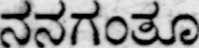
ನನಗಂತೂ
